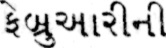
ફેબ્રુઆરીની
